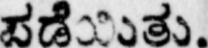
ಪಡೆಯಿತು.
